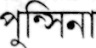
পুন্সিনা
